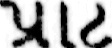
પ્રાટ
